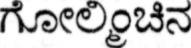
ಗೋಲ್ಮಿಂಚಿನ
